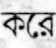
করে
